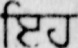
ਇਹ
